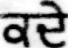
ਕਦੇ
